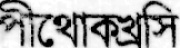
পীথোকখ্রসি
